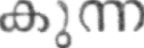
കുന്ന
